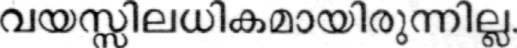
വയസ്സിലധികമായിരുന്നില്ല.
